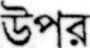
উপর
